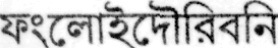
ফংলোইদৌরিবনি
